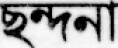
ছন্দনা
